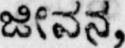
ಜೀವನ,
